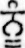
ਨੂੰ
